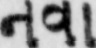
નવા
